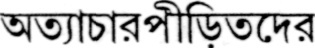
অত্যাচারপীড়িতদের
